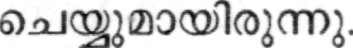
ചെയ്യുമായിരുന്നു.
